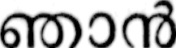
ഞാന്‍
